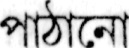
পাঠানো
